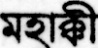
মহাক্কী
